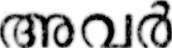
അവര്‍
